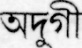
অদুগী
